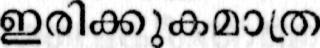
ഇരിക്കുകമാത്ര
